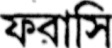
ফরাসি
